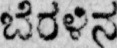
ಬೆರಳಿನ
